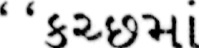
"કચ્છમાં
